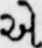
એ
